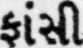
ફાંસી
